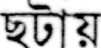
ছটায়
